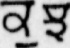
ਕੁਝ
